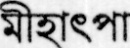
মীহাৎপা
